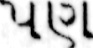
પણ
